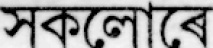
সকলোৰে
